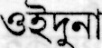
ওইদুনা
